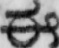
ಈ
